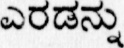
ಎರಡನ್ನು
